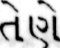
તેણે
